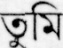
তুমি
